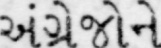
અંગ્રેજોને
